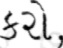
કરો,
